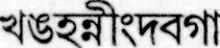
খঙহন্নীংদবগা
